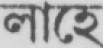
লাহে
